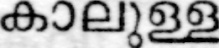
കാലുള്ള
